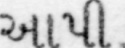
આપી.
